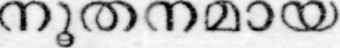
നൂതനമായ
